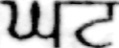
ਘਟ
